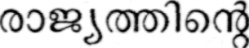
രാജ്യത്തിന്റെ
